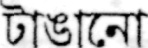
টাঙানো
